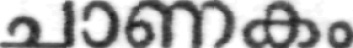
ചാണകം
